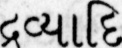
દ્રવ્યાદિ
